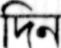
দিন
